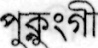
পুক্নুংগী
